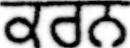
ਕਰਨ
